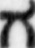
ಗ
